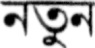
নতুন
